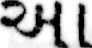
આ
